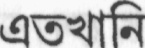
এতখানি
